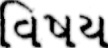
વિષય
